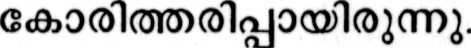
കോരിത്തരിപ്പായിരുന്നു.
